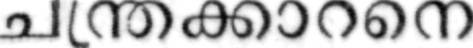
ചന്ത്രക്കാറനെ
